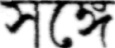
সঙ্গে
